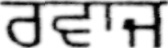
ਰਵਾਜ
